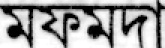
মফমদা
